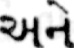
અને
